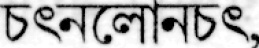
চৎনলোনচৎ,
